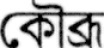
কৌব্রূ
